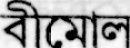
বীমোল
